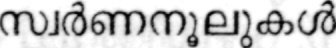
സ്വര്‍ണനൂലുകള്‍
